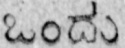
ಒಂದು
